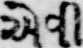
એવી
